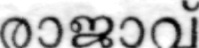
രാജാവ്
